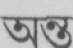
অন্ত
